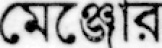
মেঞ্জোর
